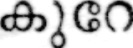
കുറേ
